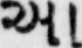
આ
